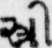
સ્ત્રી
